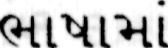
ભાષામાં
